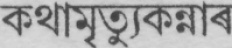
কথামৃত্যুকন্নাৰ
